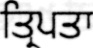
ਤ੍ਰਿਪਤਾ
